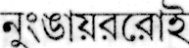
নুংঙায়ররোই
